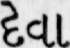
દેવા
